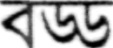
বড্ড
